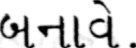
બનાવે.
